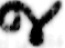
જ
